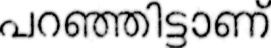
പറഞ്ഞിട്ടാണ്
